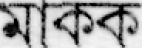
মাকক
